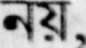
নয়,
